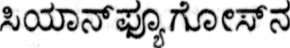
ಸಿಯಾನ್ ಫ್ಯೂಗೋಸ್ ನ
